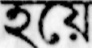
হয়ে
